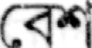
বেশ
